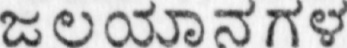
ಜಲಯಾನಗಳ
